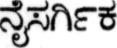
ನೈಸರ್ಗಿಕ
